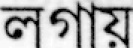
লগায়
